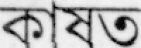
কাষত
